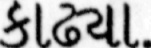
કાઢ્યા.
